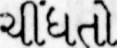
ચીંધતો
